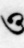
ও
